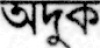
অদুক
